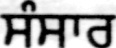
ਸੰਸਾਰ
